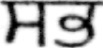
ਸਭ
